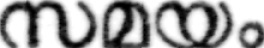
സമയം
